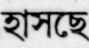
হাসছে
